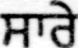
ਸਾਰੇ
